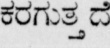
ಕರಗುತ್ತದೆ
